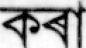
কৰা
